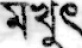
মখুৎ
